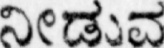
ನೀಡುವ
